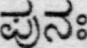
ಪುನಃ
